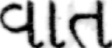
વાત
